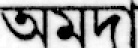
অমদা
